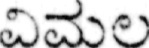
ವಿಮಲ
